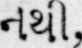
નથી,તેમ
